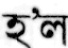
হ'ল
